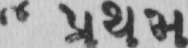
“પ્રથમ
